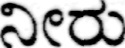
ನೀರು
